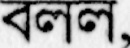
বলল,
